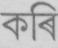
কৰি
